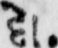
દો.
